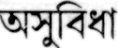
অসুবিধা
